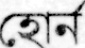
হোর্ন
